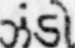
ઝંડો
